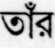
তাঁর
